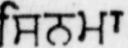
ਸਿਨਮਾ
